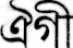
ঐগী
